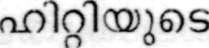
ഹിറ്റിയുടെ
